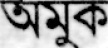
অমুক
